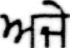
ਅਜੇ
